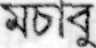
মচাবু
